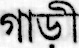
গাড়ী
